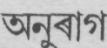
অনুৰাগ
